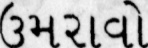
ઉમરાવો
